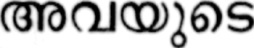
അവയുടെ
